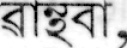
ৱান্থবা,
